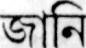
জানি
